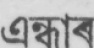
এন্ধাৰ
